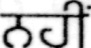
ਨਹੀਂ
